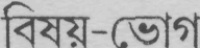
বিষয়-ভোগ
